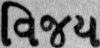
વિજય
